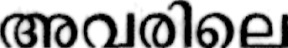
അവരിലെ
